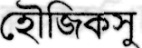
হৌজিকসু
